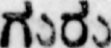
ಗುರು
